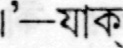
৷’—যাক্
